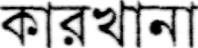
কারখানা
